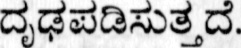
ದೃಢಪಡಿಸುತ್ತದೆ.
